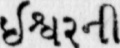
ઈશ્વરની
